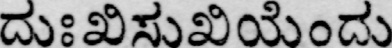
ದುಃಖಿಸುಖಿಯೆಂದು
